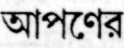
আপণের
